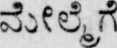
ಮೇಲ್ಮೆಗೆ
